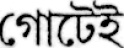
গোটেই
